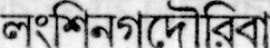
লংশিনগদৌরিবা
